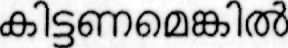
കിട്ടണമെങ്കില്‍
